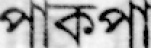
পাকপা
